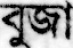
বুজা
